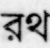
রথ
